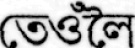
তেওঁলৈ
